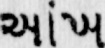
આંખ
